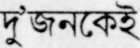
দু’জনকেই
